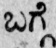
ಬಗ್ಗೆ
